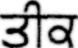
ਤੀਕ
